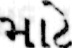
માટે
